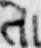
તો
